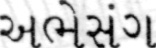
અભેસંગ
